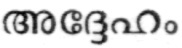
അദ്ദേഹം
